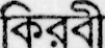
কিরবী
